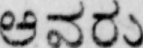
ಅವರು
